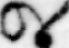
જ
